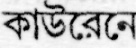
কাউরেনে
